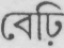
বেঢ়ি
